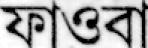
ফাওবা
